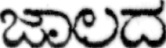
ಜಾಲದ
